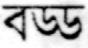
বড্ড
